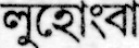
লুহোংবা
